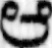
ಆ
